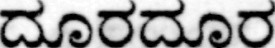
ದೂರದೂರ
